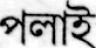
পলাই
